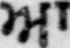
ਆ
